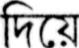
দিয়ে
